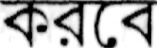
করবে
